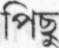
পিছু
